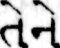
તેને
